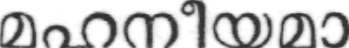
മഹനീയമാ
